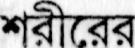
শরীরের
